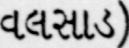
(જિ.વલસાડ)
